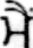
ਮੈਂ
